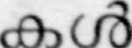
കള്‍
